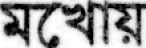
মখোয়
